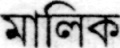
মালিক
